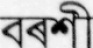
বৰশী
